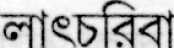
লাৎচরিবা
